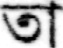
তা
